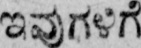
ಇವುಗಳಿಗೆ
